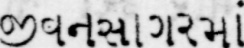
જીવનસાગરમા
